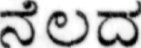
ನೆಲದ
